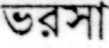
ভরসা
